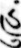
હું
